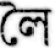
লৈ
